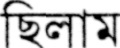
ছিলাম
